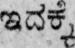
ಇದಕ್ಕೆ
